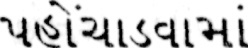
પહોંચાડવામાં
